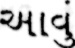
આવું
